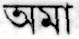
অমা
